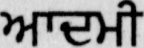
ਆਦਮੀ
